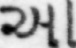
આ
